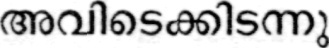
അവിടെക്കിടന്നു
